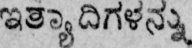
ಇತ್ಯಾದಿಗಳನ್ನು
